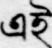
এই
